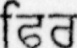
ਫਿਰ
